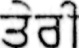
ਤੇਰੀ
